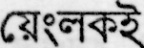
য়েংলকই
